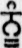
ਨੂੰ
